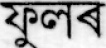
ফুলৰ
